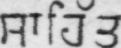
ਸਾਹਿੱਤ
